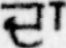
ਦਾ
